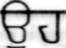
ਉਹ
